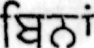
ਬਿਨਾਂ
